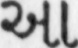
આ
